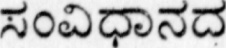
ಸಂವಿಧಾನದ
